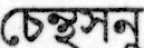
চেন্থসনু
